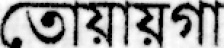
তোয়ায়গা
